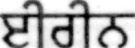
ਈਰੀਨ
